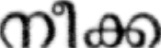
നീക്ക
